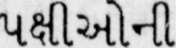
પક્ષીઓની
